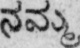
ನಮ್ಮ
